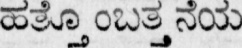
ಹತ್ತೊಂಬತ್ತನೆಯ
